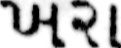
ખરા
